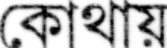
কোথায়
